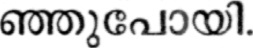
ഞ്ഞുപോയി.
